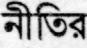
নীতির
